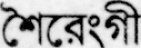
শৈরেংগী
